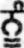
ਨੂੰ
